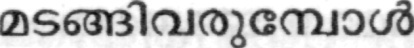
മടങ്ങിവരുമ്പോള്‍
